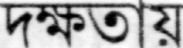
দক্ষতায়
